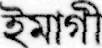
ইমাগী
